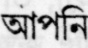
আপনি
